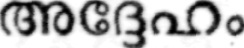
അദ്ദേഹം
